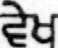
ਵੇਖ
